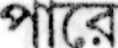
পারে
